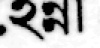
হেন্না
